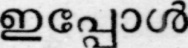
ഇപ്പോള്‍
